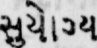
સુયોગ્ય
